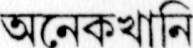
অনেকখানি
